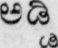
ಅಡ್ಡಿ
